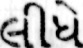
લીધે
